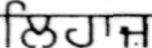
ਲਿਹਾਜ਼
